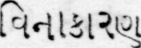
વિનાકારણ
